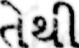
તેથી
